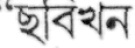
"ছবিখন
